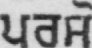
ਪਰਸੋ
